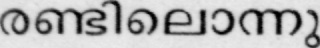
രണ്ടിലൊന്നു
